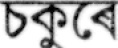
চকুৰে
